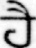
ਹੈ
